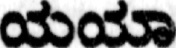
ಯಯಾ
